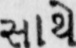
સાથે
